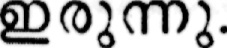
ഇരുന്നു.
